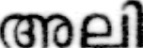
അലി
